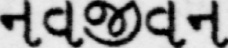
નવજીવન
